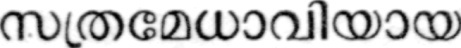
സത്രമേധാവിയായ
